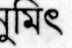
নুমিৎ
